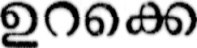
ഉറക്കെ
